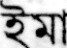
ইমা
